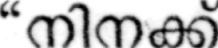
“നിനക്ക്
